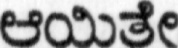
ಆಯಿತೇ
